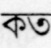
কত
